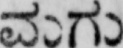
ಮಗು
